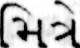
મિત્રે
